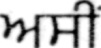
ਅਸੀਂ
